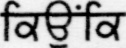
ਕਿਉਂਕਿ
